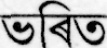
ভৰিত
